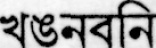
খঙনবনি
